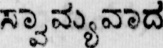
ಸ್ವಾಮ್ಯವಾದ
